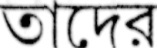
তাদের
